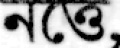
নত্তে,
